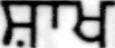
ਸ਼ਾਖ
